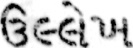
ઉલ્લેખ
